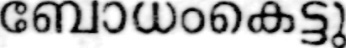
ബോധംകെട്ടു
